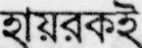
হায়রকই
